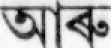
আৰু
